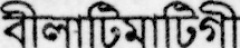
বীলাটিমাটিগী
